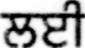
ਲਈ
